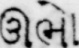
ઊભો
